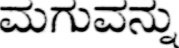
ಮಗುವನ್ನು
